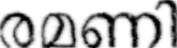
രമണി
